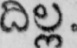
ದಿಲ್ಲ.
